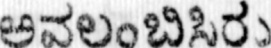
ಅವಲಂಬಿಸಿರು
